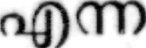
എന്ന
